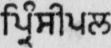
ਪ੍ਰਿੰਸੀਪਲ
